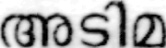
അടിമ
